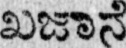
ಖಜಾನೆ
